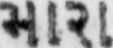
મારા
